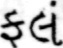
ફલં
